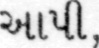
આપી,
